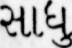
સાધુ
